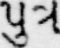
પુત્ર
